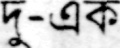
দু-এক
